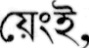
য়েংই,
